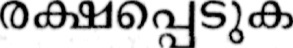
രക്ഷപ്പെടുക
